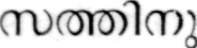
സത്തിനു
